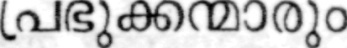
പ്രഭുക്കന്മാരും
